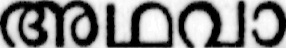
അഥവാ
